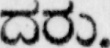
ದರು.
